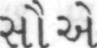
સૌએ
